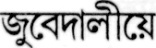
জুবেদালীয়ে
